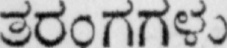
ತರಂಗಗಳು
